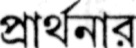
প্রার্থনার
